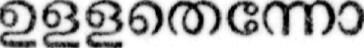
ഉളളതെന്നോ
